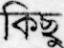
কিছু
